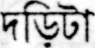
দড়িটা
